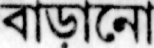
বাড়ানো
